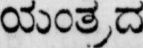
ಯಂತ್ರದ
